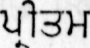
ਪ੍ਰੀਤਮ
